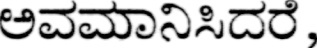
ಅವಮಾನಿಸಿದರೆ,
